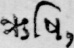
ઋષિ,
